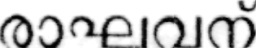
രാഘവന്
